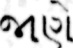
જાણે
